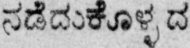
ನಡೆದುಕೊಳ್ಳದ
